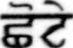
ਛੋਟੇ
